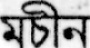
মচীন
